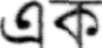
এক
